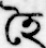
হৈ
